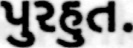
પુરહુત.
